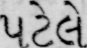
પટેલે
